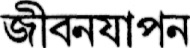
জীবনযাপন
